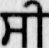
ਸੀ
